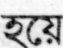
হয়ে
